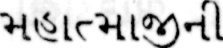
મહાત્માજીની
